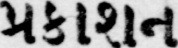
પ્રકાશન
